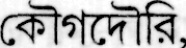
কৌগদৌরি,
